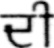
ਦੀ
